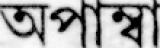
অপাম্বা
